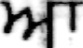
ਆ
